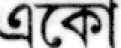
একো
